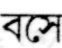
বসে
